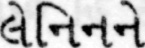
લેનિનને
